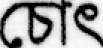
চোৎ
